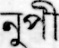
নুপী
